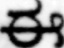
ಈ
